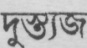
দুস্ত্যজ
